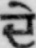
ਦੇ
